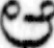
ಆ
